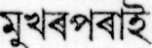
মুখৰপৰাই
